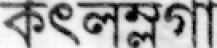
কৎলম্লগা
